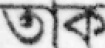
তাক
